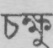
চক্ষু
